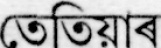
তেতিয়াৰ
